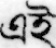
এই
